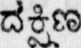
ದಕ್ಷಿಣ
